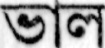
ভাল
